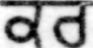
ਕਰ
